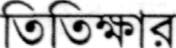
তিতিক্ষার
